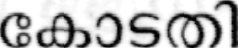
കോടതി
